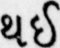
થઈ
